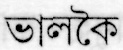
ভালকৈ
